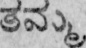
ತಮ್ಮ
